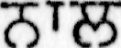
ਨਾਲ
